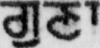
ਗੁਣਾ
